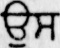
ਉਸ
